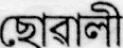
ছোৱালী
